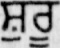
ਸ਼ੁਰੂ
